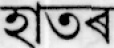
হাতৰ
